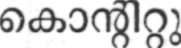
കൊന്റിറ്റു
